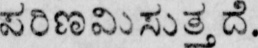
ಪರಿಣಮಿಸುತ್ತದೆ.
